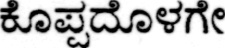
ಕೊಪ್ಪದೊಳಗೇ
